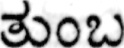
ತುಂಬ
